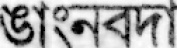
ঙাংনবদা
